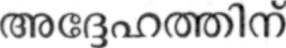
അദ്ദേഹത്തിന്
